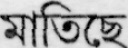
মাতিছে
